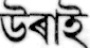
উৰাই
